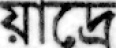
য়াদ্রে
